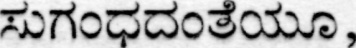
ಸುಗಂಧದಂತೆಯೂ,
